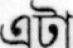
এটা
